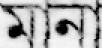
মানা
